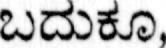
ಬದುಕೂ,
